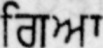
ਗਿਆ
